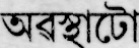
অৱস্হাটো
